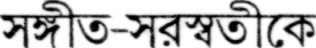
সঙ্গীত-সরস্বতীকে
